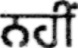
ਨਹੀਂ
